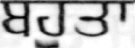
ਬਹੁਤਾ
